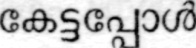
കേട്ടപ്പോള്‍
